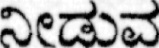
ನೀಡುವ
